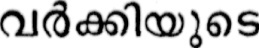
വര്‍ക്കിയുടെ
